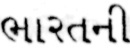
ભારતની
